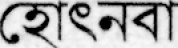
হোৎনবা
